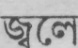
জ্বলে
